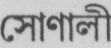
সোণালী
